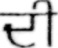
ਦੀ
